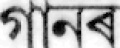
গানৰ
